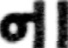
ના
